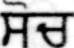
ਸੋਚ
